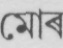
মোৰ
